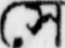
সে
